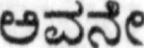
ಅವನೇ
